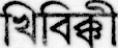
খিবিক্কী
